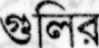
গুলির
